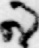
જે
